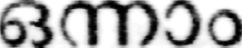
ഒന്നാം
